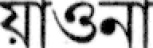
য়াওনা
